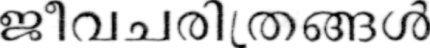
ജീവചരിത്രങ്ങള്‍
